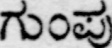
ಗುಂಪು
